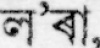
ল'ৰা,
